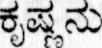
ಕೃಷ್ಣನು
